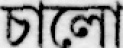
চালো
